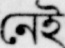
নেই
